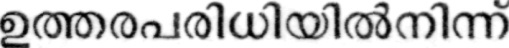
ഉത്തരപരിധിയില്‍നിന്ന്
